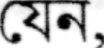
যেন,
